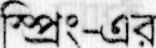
স্প্রিং-এর
